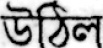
উঠিল
